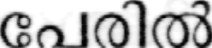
പേരില്‍
